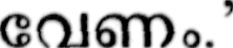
വേണം.’
